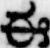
ಈ
